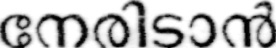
നേരിടാന്‍
